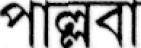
পাল্লবা
